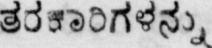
ತರಕಾರಿಗಳನ್ನು
